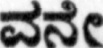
ವನೇ
